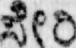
ಸೇರಿ
